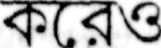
করেও
